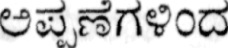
ಅಪ್ಪಣೆಗಳಿಂದ
